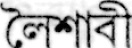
লৈশাবী
